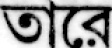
তারে
